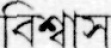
বিশ্বাস
